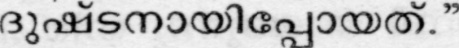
ദുഷ്ടനായിപ്പോയത്."
